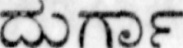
ದುರ್ಗಾ
